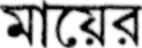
মায়ের
